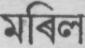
মৰিল
